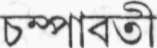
চম্পাবতী
